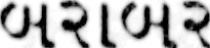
બરાબર
